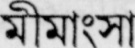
মীমাংসা
